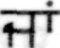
ਜਾਂ
